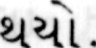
થયો.
